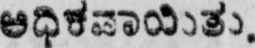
ಅಧಿಕವಾಯಿತು.
